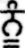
ਨੂੰ
